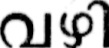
വഴി
